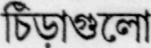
চিঁড়াগুলো
